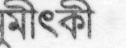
মীৎকী
